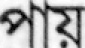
পায়
